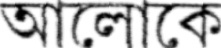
আলোকে
